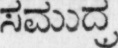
ಸಮುದ್ರ
